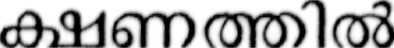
ക്ഷണത്തില്‍
